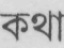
কথা
